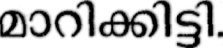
മാറിക്കിട്ടി.
